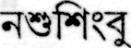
নশুশিংবু
